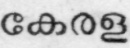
കേരള
